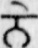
ਨੇ
